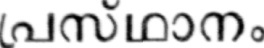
പ്രസ്ഥാനം
